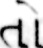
તો
